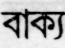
বাক্য
